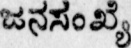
ಜನಸಂಖ್ಯೆ
